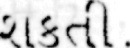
શકતી.
